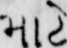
માટે
